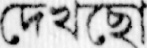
দেখছো
